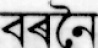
বৰনৈ
